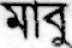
মাবু
